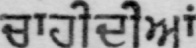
ਚਾਹੀਦੀਆਂ
